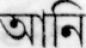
আনি
